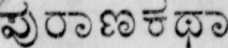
ಪುರಾಣಕಥಾ
